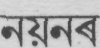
নয়নৰ
